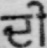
ਦੀ
